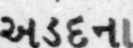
અડદના
